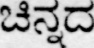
ಚಿನ್ನದ
